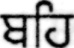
ਬਹਿ
